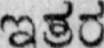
ಇತರ
